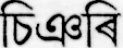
চিঞৰি
